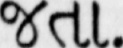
જતા.
